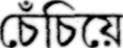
চেঁচিয়ে
